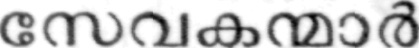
സേവകന്മാര്‍
